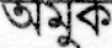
অমুক
